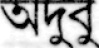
অদুবু
